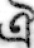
ঐ
